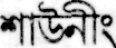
শাউনীং
